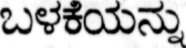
ಬಳಕೆಯನ್ನು
